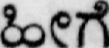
ಹೀಗೆ
